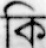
কি
